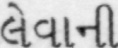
લેવાની
